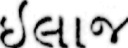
ઇલાજ
